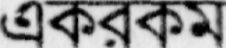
একরকম
